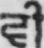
ਵੀ
